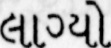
લાગ્યો
